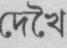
দেখৈ
